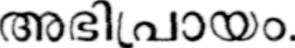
അഭിപ്രായം.
